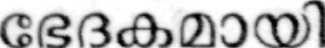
ഭേദകമായി
